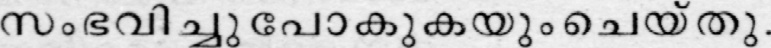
സംഭവിച്ചുപോകുകയുംചെയ്തു.
